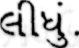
લીધું.
